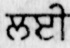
ਲਈ
